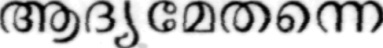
ആദ്യമേതന്നെ
